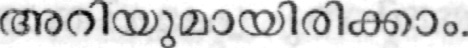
അറിയുമായിരിക്കാം.
